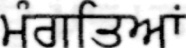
ਮੰਗਤਿਆਂ
